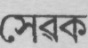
সেৱক
